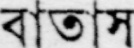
বাতাস
